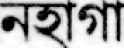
নহাগা
